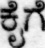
ಕೈಗೆ
